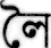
লৈ
